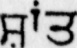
ਸ਼ਾਂਤ
